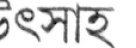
উৎসাহ
